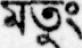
মতুং
